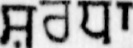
ਸ਼ਰਧਾ
